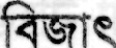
বিজাৎ
